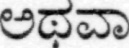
ಅಥವಾ
